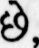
છે,
